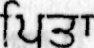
ਪਿਤਾ
